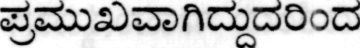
ಪ್ರಮುಖವಾಗಿದ್ದುದರಿಂದ
